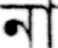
না
